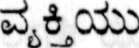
ವ್ಯಕ್ತಿಯು
